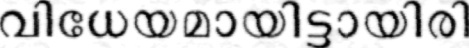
വിധേയമായിട്ടായിരി
